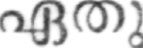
ഏതു
